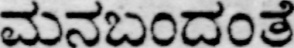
ಮನಬಂದಂತೆ
